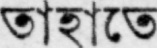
তাহাতে
